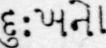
દુઃખનો
